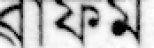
ৱাফম
